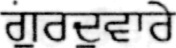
ਗੁਰਦੁਵਾਰੇ
